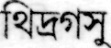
থিদ্রগসু
